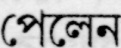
পেলেন
